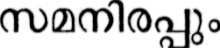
സമനിരപ്പും
